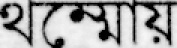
থম্মোয়
